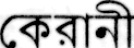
কেরানী
